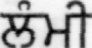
ਲੰਮੀ
